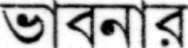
ভাবনার
